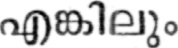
എങ്കിലും
